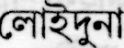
লোইদুনা
